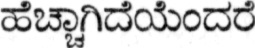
ಹೆಚ್ಚಾಗಿದೆಯೆಂದರೆ
